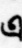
এ
